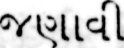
જણાવી
